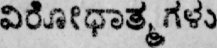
ವಿರೋಧಾತ್ಮಗಳು
